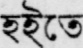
হইতে
